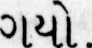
ગયો.
